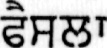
ਫੈਸਲਾ
